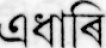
এধাৰি
